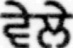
ਵੇਲੇ
